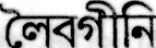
লৈবগীনি
